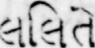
લલિતે
